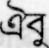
ঐবু
